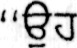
''ਉਹ
